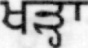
ਖੜ੍ਹਾ
